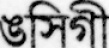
ঙসিগী
